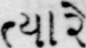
ત્યારે
